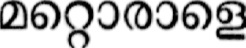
മറ്റൊരാളെ
